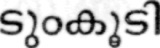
ടുംകൂടി
